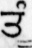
ਤੂੰ
